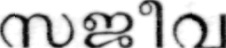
സജീവ
